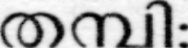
തമ്പി:
